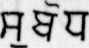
ਸੁਬੋਧ
